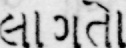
લાગતો
